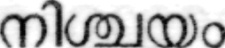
നിശ്ചയം
